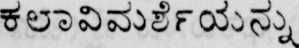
ಕಲಾವಿಮರ್ಶೆಯನ್ನು
